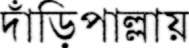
দাঁড়িপাল্লায়
